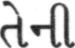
તેની
